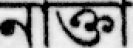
নাক্তা
